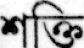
শক্তি
